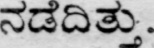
ನಡೆದಿತ್ತು.
